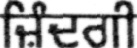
ਜ਼ਿੰਦਗੀ
